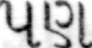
પણ
